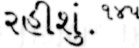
રહીશું.૧૪૫
